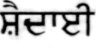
ਸ਼ੈਦਾਈ
